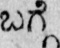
ಬಗ್ಗೆ
